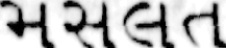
મસલત
